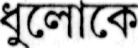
ধুলোকে
